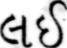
લઈ
